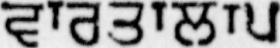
ਵਾਰਤਾਲਾਪ
